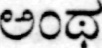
ಅಂಥ
